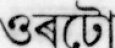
ওৰটো
